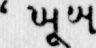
'ખૂબ
